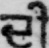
ਦੀ
